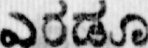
ಎರಡೂ
